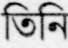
তিনি
